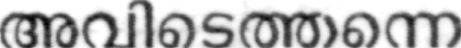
അവിടെത്തന്നെ
